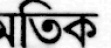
মতিক
